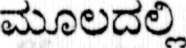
ಮೂಲದಲ್ಲಿ
